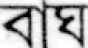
বাঘ
